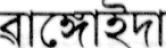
ৱাঙ্গোইদা
